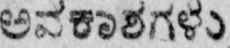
ಅವಕಾಶಗಳು
